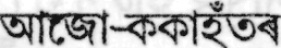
আজো-ককাহঁতৰ
